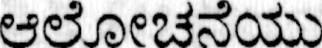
ಆಲೋಚನೆಯು
